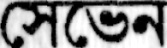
সেভেন
